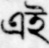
এই
